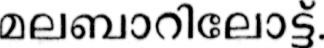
മലബാറിലോട്ട്.
